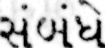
સંબંધે
